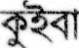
কুইবা
